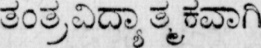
ತಂತ್ರವಿದ್ಯಾತ್ಮಕವಾಗಿ
